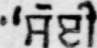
'ਸੋਈ
